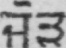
ਜੋੜ
